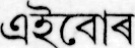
এইবোৰ
